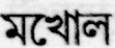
মখোল
